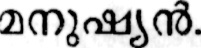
മനുഷ്യന്‍.
